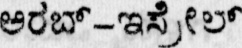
ಅರಬ್-ಇಸ್ರೇಲ್
